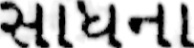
સાધના
